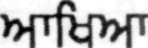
ਆਖਿਆ
